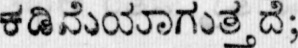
ಕಡಿಮೆಯಾಗುತ್ತದೆ;
